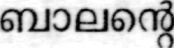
ബാലന്റെ
